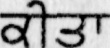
ਕੀਤਾ
